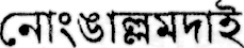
নোংঙাল্লমদাই
